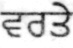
ਵਰਤੇ
